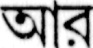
আর
